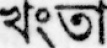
খংতা
